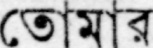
তোমার
